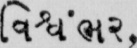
વિશ્વંભર,
